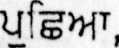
ਪੁਛਿਆ,
